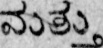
ಮತ್ತು
